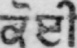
ਕੋਈ
